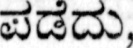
ಪಡೆದು,
